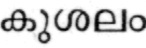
കുശലം
